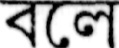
বলে
